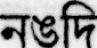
নঙদি
